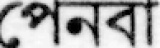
পেনবা
